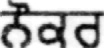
ਨੌਕਰ
